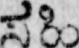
ಸಹಿ
